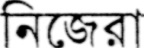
নিজেরা
